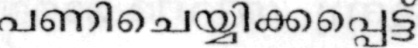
പണിചെയ്യിക്കപ്പെട്ട്
